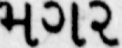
મગર
